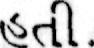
હતી.
